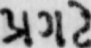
પ્રગટે
